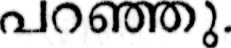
പറഞ്ഞു.
